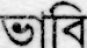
ভাবি
